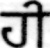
ਹੀ
